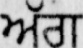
ਅੱਗ
